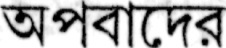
অপবাদের
